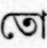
তো
